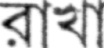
রাখা
